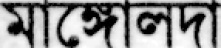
মাঙ্গোন্দা
